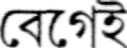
বেগেই
